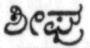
ಶೀಘ್ರ
